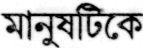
মানুষটিকে
